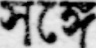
সঙ্গে
